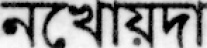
নখোয়দা
